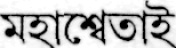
মহাশ্বেতাই
